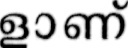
ളാണ്
